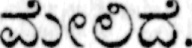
ಮೇಲಿದೆ.
